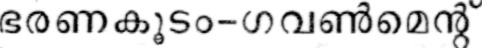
ഭരണകൂടം-ഗവണ്‍മെന്റ്
